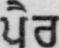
ਪੈਰ
